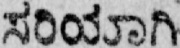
ಸರಿಯಾಗಿ
